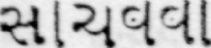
સાચવવા
